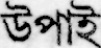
উপাই
